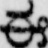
ಈ
